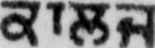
ਕਾਲਜ
